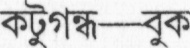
কটুগন্ধ–বুক
